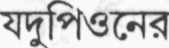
যদুপিওনের
